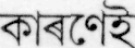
কাৰণেই
